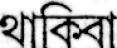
থাকিবা
